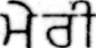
ਮੇਰੀ
